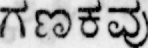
ಗಣಕವು
